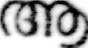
ആ
